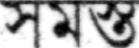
সমস্ত
